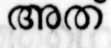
അത്
